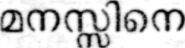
മനസ്സിനെ
